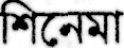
শিনেমা
